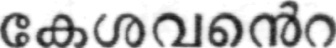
കേശവന്റെ
